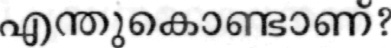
എന്തുകൊണ്ടാണ്?
